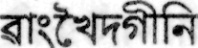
ৱাংখৈদগীনি
